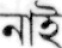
নাই
